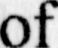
of
